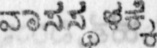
ವಾಸಸ್ಥಳಕ್ಕೆ
